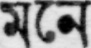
মনে
